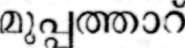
മുപ്പത്താറ്
